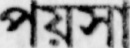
পয়সা
